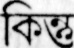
কিন্তু
